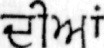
ਦੀਆਂ
